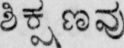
ಶಿಕ್ಷಣವು
